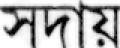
সদায়
